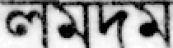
লমদম
